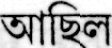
আছিল
